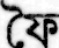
ফৈ
